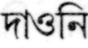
দাওনি
